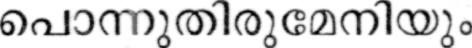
പൊന്നുതിരുമേനിയും
